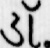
ડો.
